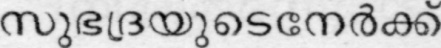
സുഭദ്രയുടെനേര്‍ക്ക്
